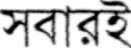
সবারই
